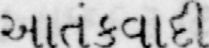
આતંકવાદી
